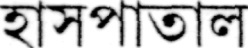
হাসপাতাল
